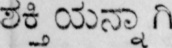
ಶಕ್ತಿಯನ್ನಾಗಿ
